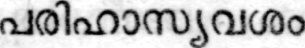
പരിഹാസ്യവശം
